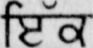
ਇੱਕ
